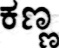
ಕಣ್ಣ
